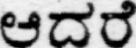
ಆದರೆ
